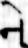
ને
